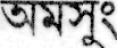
অমসুং
